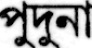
পুদুনা
